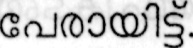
പേരായിട്ട്.
